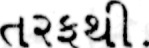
તરફથી.
